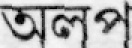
অলপ
